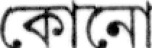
কোনো
